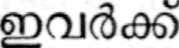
ഇവര്‍ക്ക്
